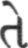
તે
